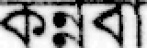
কন্নবা
